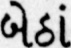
બેઠાં
